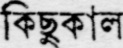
কিছুকাল
